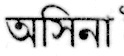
অসিনা
